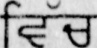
ਵਿੱਚ
